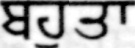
ਬਹੁਤਾ
